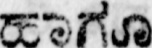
ಹಾಗೂ
